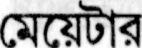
মেয়েটার
